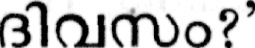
ദിവസം?’
